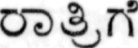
ರಾತ್ರಿಗೆ
